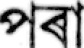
পৰা
